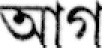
আগ
